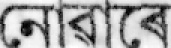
নোৱাৰে
